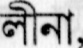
লীনা,
